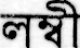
লম্বী
